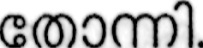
തോന്നി.
